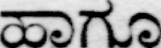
ಹಾಗೂ
